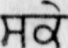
ਸਕੇ
